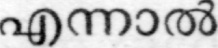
എന്നാല്‍
